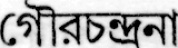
গৌরচন্দ্রনা
